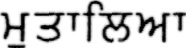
ਮੁਤਾਲਿਆ
